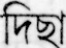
দিছা
